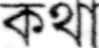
কথা
